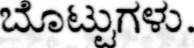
ಬೊಟ್ಟುಗಳು.
